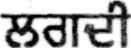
ਲਗਦੀ
